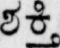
ಶಕ್ತಿ
